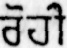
ਰੋਹੀ
